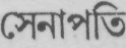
সেনাপতি
